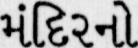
મંદિરનો
